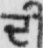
ਦੀ
